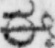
ಈ
